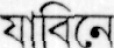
যাবিনে
